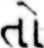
તો
